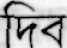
দিব
